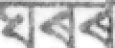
ঘৰৰ
